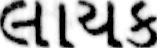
લાયક
